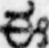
ಈ
